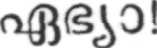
ഏഭ്യാ!
